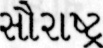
સૌરાષ્ટ્ર
